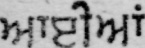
ਆਈਆਂ
